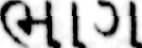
ભાગ
